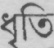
ধৃতি
